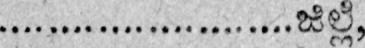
........................ಜಿಲ್ಲೆ,
